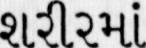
શરીરમાં
